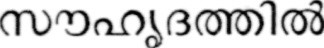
സൌഹൃദത്തില്‍
